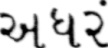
અધરં
